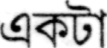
একটা
